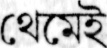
থেমেই
